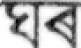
ঘৰ
